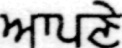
ਆਪਣੇ
